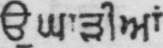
ਉਘਾੜੀਆਂ
